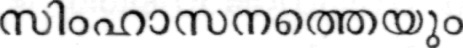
സിംഹാസനത്തെയും
